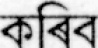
কৰিব
